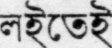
লইতেই
